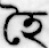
হৈ
